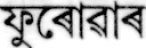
ফুৰোৱাৰ
